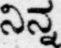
ನಿನ್ನ
